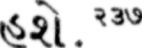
હશે.૨૩૭
